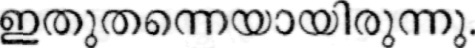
ഇതുതന്നെയായിരുന്നു.
